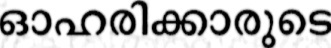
ഓഹരിക്കാരുടെ
